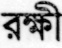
রক্ষী
